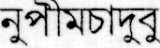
নুপীমচাদুবু
